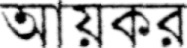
আয়কর
